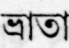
ভ্রাতা
